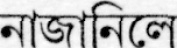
নাজানিলে
